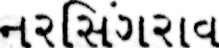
નરસિંગરાવ
